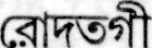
রোদতগী
